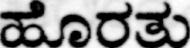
ಹೊರತು
